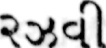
રઝવી
